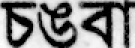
চঙবা
